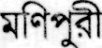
মণিপুরী
